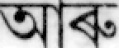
আৰু
